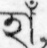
হাঁ,
